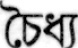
চৈধ্য
